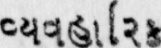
વ્યવહારિક
